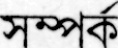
সম্পর্ক
